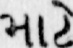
માટે
